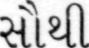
સૌથી
